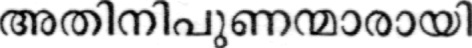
അതിനിപുണന്മാരായി
